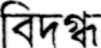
বিদগ্ধ
